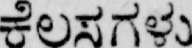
ಕೆಲಸಗಳು
